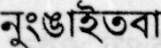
নুংঙাইতবা
